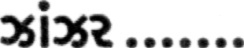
ઝાંઝર......
